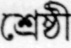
শ্রেষ্ঠী
